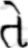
તે
